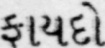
ફાયદો
